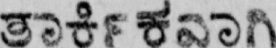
ತಾರ್ಕಿಕವಾಗಿ
